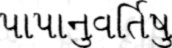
પાપનુવર્તિષુ
